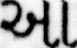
આ
